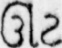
ઊંટ
